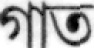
গাত
